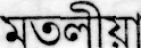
মতলীয়া
